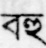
বহু
